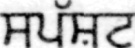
ਸਪੱਸ਼ਟ
